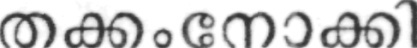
തക്കംനോക്കി
